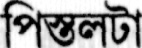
পিস্তলটা
